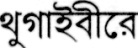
থুগাইবীরে
